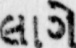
લાગે
